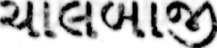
ચાલબાજી
